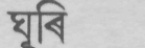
ঘূৰি
